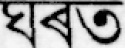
ঘৰত
